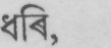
ধৰি,
